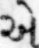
એ
